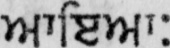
ਆਇਆ:
